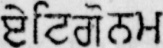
ਏਟਿਗੋਨਮ
